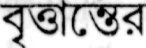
বৃত্তান্তের
